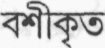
বশীকৃত
